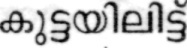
കുട്ടയിലിട്ട്
